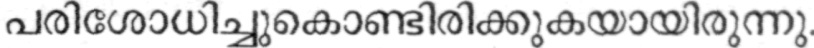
പരിശോധിച്ചുകൊണ്ടിരിക്കുകയായിരുന്നു.
